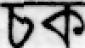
চক
